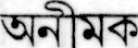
অনীমক
